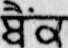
ਬੈਂਕ
